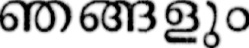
ഞങ്ങളും
